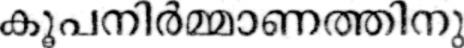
കൂപനിര്‍മ്മാണത്തിനു
